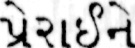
પ્રેરાઈને
